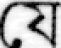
যে
